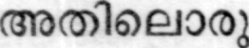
അതിലൊരു
